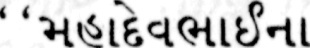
"મહાદેવભાઈના
